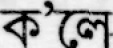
ক'লে
